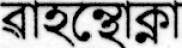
ৱাহন্থোক্না
